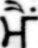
ਮੈਂ
